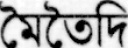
মৈতৈদি
